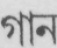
গান
